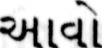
આવો
